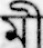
মী
